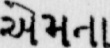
એમના
